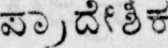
ಪ್ರಾದೇಶಿಕ
